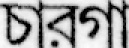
চারগা
